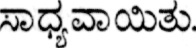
ಸಾಧ್ಯವಾಯಿತು.
